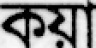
কয়া
